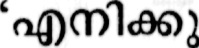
‘എനിക്കു
